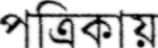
পত্রিকায়
